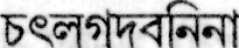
চৎলগদবনিনা
